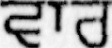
ਵਾਰ
